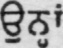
ਉਨ੍ਹਾਂ
